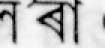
ল'ৰা
